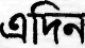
এদিন
